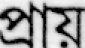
প্রায়
